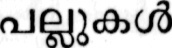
പല്ലുകള്‍
